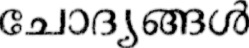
ചോദ്യങ്ങള്‍
